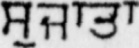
ਸੁਜਾਤਾ
